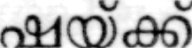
ഷയ്ക്ക്
